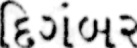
દિગંબર
